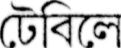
টেবিলে
